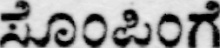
ಸೊಂಪಿಂಗೆ
